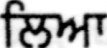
ਲਿਆ
